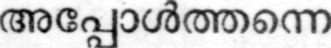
അപ്പോള്‍ത്തന്നെ
